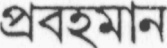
প্রবহমান
